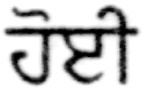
ਹੋਈ
